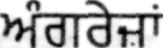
ਅੰਗਰੇਜਾਂ
